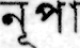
নূপা
